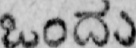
ಒಂದು
